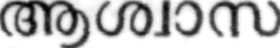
ആശ്വാസ
